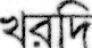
খরদি
